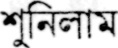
শুনিলাম
